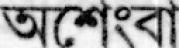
অশেংবা
